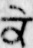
ਕੇ
